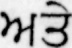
ਅਤੇ
